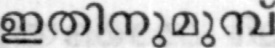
ഇതിനുമുമ്പ്
